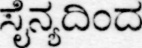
ಸೈನ್ಯದಿಂದ
